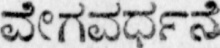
ವೇಗವರ್ಧನೆ
